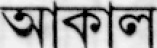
আকাল
